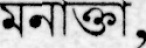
মনাক্তা,
